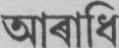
আৰাধি
